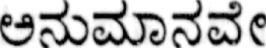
ಅನುಮಾನವೇ
